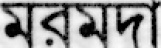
মরমদা
